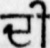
ਦੀ
